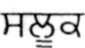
ਸਲੂਕ
